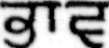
ਭਾਵ
